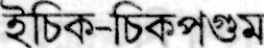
ইচিক-চিকপগুম
